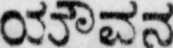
ಯೌವನ
